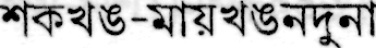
শকখঙ-মায়খঙনদুনা
